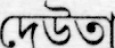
দেউতা
